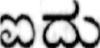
ಐದು
